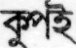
কুপই
